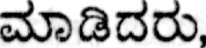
ಮಾಡಿದರು,
